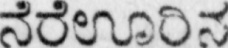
ನೆರೆಊರಿನ
